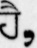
ਹੈ,
